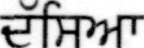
ਦੱਸਿਆ
